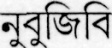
নুবুজিবি
